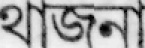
থাজনা
